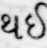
થઈ
